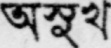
অসুখ
